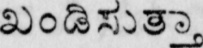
ಖಂಡಿಸುತ್ತಾ
